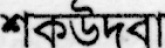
শকউদবা
